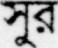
সুর
